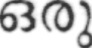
ഒരു
